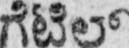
ಗೆಟೆಲ್
